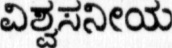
ವಿಶ್ವಸನೀಯ
